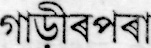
গাড়ীৰপৰা
